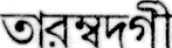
তারম্বদগী
